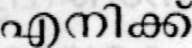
എനിക്ക്
